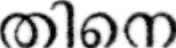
തിനെ
